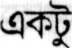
একটু
